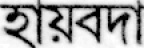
হায়বদা
